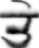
ਤੇ
